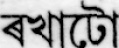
ৰখাটো
